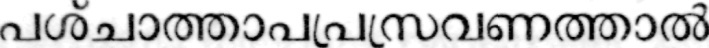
പശ്ചാത്താപപ്രസ്രവണത്താല്‍
